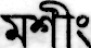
মশীং
